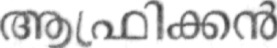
ആഫ്രിക്കന്‍
